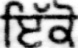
ਇੱਕੋ
